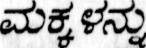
ಮಕ್ಕಳನ್ನು
